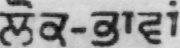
ਲੋਕ-ਭਾਵਾਂ
